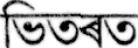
ভিতৰত
